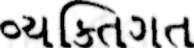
વ્યકિતગત
